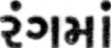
રંગમાં
